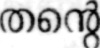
തന്റെ
